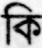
কি
